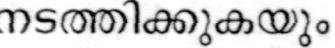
നടത്തിക്കുകയും
